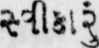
સ્વીકારું
